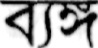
ব্যঙ্গ
